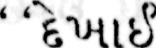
"દેખાઈ
